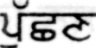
ਪੁੱਛਣ
